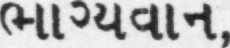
ભાગ્યવાન,
